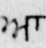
ਆ
